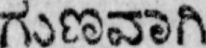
ಗುಣವಾಗಿ
